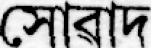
সোৱাদ
